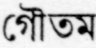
গৌতম
